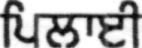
ਪਿਲਾਈ
